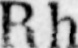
Rh
